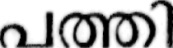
പത്തി
